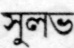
সুলভ
